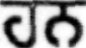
ਹਨ
